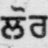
ਲੋਰ
